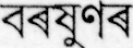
বৰষুণৰ
